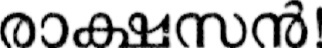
രാക്ഷസന്‍!
